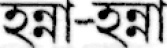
হন্না-হন্না
